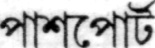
পাশপোর্ট
